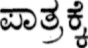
ಪಾತ್ರಕ್ಕೆ
